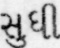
સુધી
